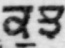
ਕੁਝ
